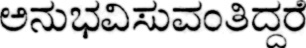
ಅನುಭವಿಸುವಂತಿದ್ದರೆ
